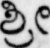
ಶ್ರೀ
